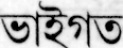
ভাইগত
